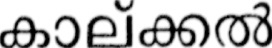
കാല്ക്കല്‍
